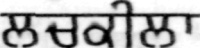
ਲਚਕੀਲਾ
